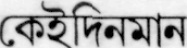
কেইদিনমান
